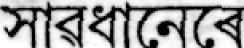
সাৱধানেৰে
